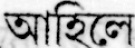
আহিলে
